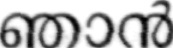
ഞാന്‍
